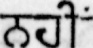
ਨਹੀਂ
